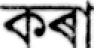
কৰা
